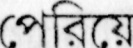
পেরিয়ে
